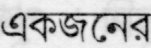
একজনের
